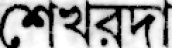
শেখরদা
